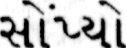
સોંપ્યો
